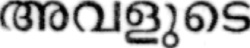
അവളുടെ
